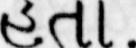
હતા.
